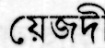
য়েজদী
